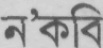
ন'কবি
